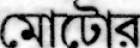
মোটোর
